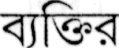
ব্যক্তির
